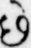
છે
